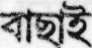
বাছাই
